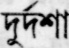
দুর্দশা
